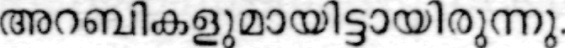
അറബികളുമായിട്ടായിരുന്നു.
